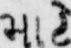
માટે
